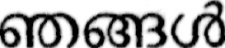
ഞങ്ങള്‍
